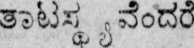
ತಾಟಸ್ಥ್ಯವೆಂದರೆ
